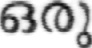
ഒരു
